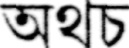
অথচ
